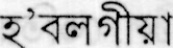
হ'বলগীয়া
